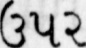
ઉપર
